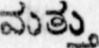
ಮತ್ತು
